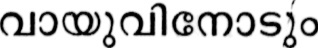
വായുവിനോടും
